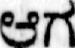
ಆಗ
